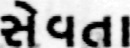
સેવતા
